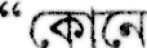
"কোনে
